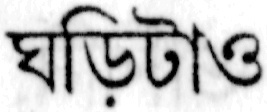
ঘড়িটাও
